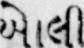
બોલી
